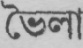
ভৈলা
